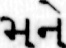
મને
